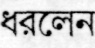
ধরলেন
